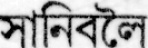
সানিবলৈ
